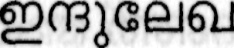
ഇന്ദുലേഖ
